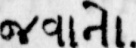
જવાનો.
